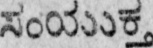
ಸಂಯುಕ್ತ
